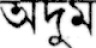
অদুম
